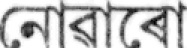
নোৱাৰো
